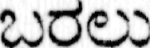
ಬರಲು
